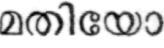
മതിയോ
